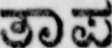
ತಾಪ
